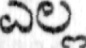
ಎಲ್ಲ
